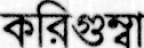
করিগুম্বা
